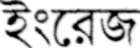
ইংরেজ
